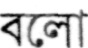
বলো
